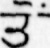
ਤੋਂ
